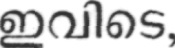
ഇവിടെ,
